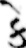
કે
